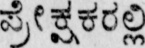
ಪ್ರೇಕ್ಷಕರಲ್ಲಿ
